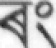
ৰং
